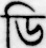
ডি
